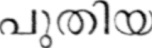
പുതിയ
